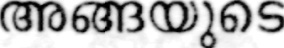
അങ്ങയുടെ
